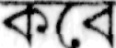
কবে
